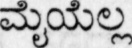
ಮೈಯೆಲ್ಲ
